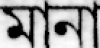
মানা
